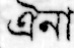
ঐনা
